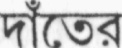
দাঁতের
